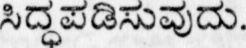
ಸಿದ್ಧಪಡಿಸುವುದು.
